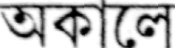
অকালে
